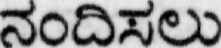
ನಂದಿಸಲು
